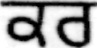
ਕਰ
